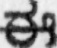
ಈ
